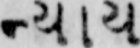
ન્યાય
